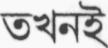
তখনই
